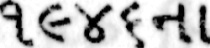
૧૯૪૬ના
